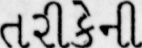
તરીકેની
